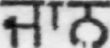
ਜਾਨ
